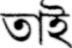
তাই
